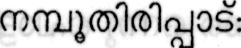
നമ്പൂതിരിപ്പാട്:
